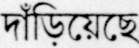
দাঁড়িয়েছে
